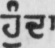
ਹੁੰਦਾ
